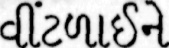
વીંટળાઈને
